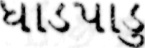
ધાડપાડુ
